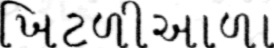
ખિટળીઆળા
